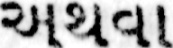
અથવા
